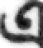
এ
